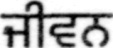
ਜੀਵਨ
